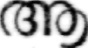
ആ
